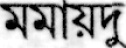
মমায়দু
